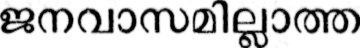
ജനവാസമില്ലാത്ത
